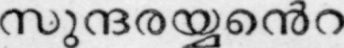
സുന്ദരയ്യന്റെ
